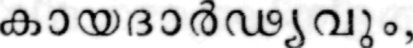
കായദാര്‍ഢ്യവും,
